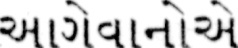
આગેવાનોએ
